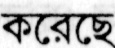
করেছে
